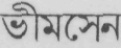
ভীমসেন
